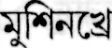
মুশিনখ্রে
